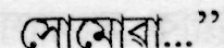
সোমোৱা..."
